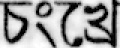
চংখ্রে
